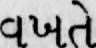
વખતે
